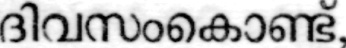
ദിവസംകൊണ്ട്,
